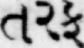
તરફ
